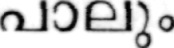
പാലും
